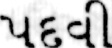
પદવી
